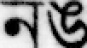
নঙ
